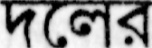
দলের
